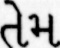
તેમ
